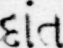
દાંત
